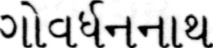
ગોવર્ધનનાથ
